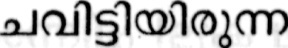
ചവിട്ടിയിരുന്ന
